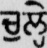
ਚੁਲ੍ਹੇ
